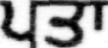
ਪਤਾ
